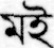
মই
